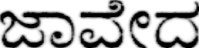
ಜಾವೇದ
